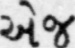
એજ
